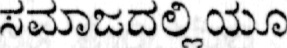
ಸಮಾಜದಲ್ಲಿಯೂ
